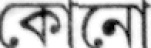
কোনো
